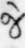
જે
